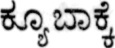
ಕ್ಯೂಬಾಕ್ಕೆ
